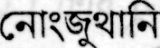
নোংজুথানি
